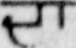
ਦਾ
